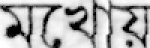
মখোয়
